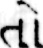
તો
